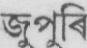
জুপুৰি
